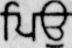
ਪਿਉ
